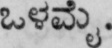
ಒಳಮೈ.
